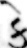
કે
